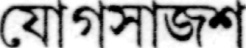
যোগসাজশ
